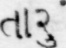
તારું
